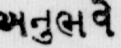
અનુભવે
